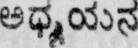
ಅಧ್ಯಯನ
